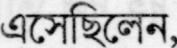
এসেছিলেন,
